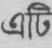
এটি
